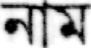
নাম
